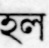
হল
